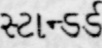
સ્ટાન્ડર્ડ
